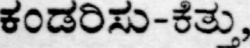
ಕಂಡರಿಸು-ಕೆತ್ತು,
